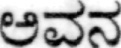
ಅವನ
